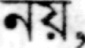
নয়,
